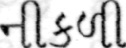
નીકળી
